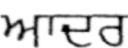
ਆਦਰ
